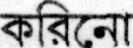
করিনো
